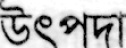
উৎপদা
